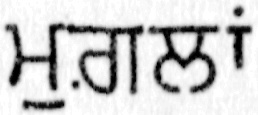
ਮੁਗ਼ਲਾਂ
